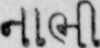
નાભી
